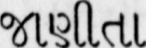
જાણીતા
